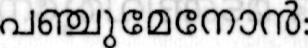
പഞ്ചുമേനോന്‍:
